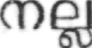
നല്ല
